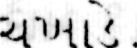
ચખાડે.
